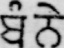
ਬੰਨੇ
